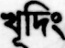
খূদিং
